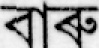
বাৰু
